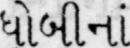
ધોબીનાં
